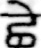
ਛੇ
